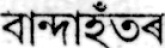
বান্দাহঁতৰ
